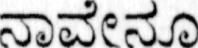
ನಾವೇನೂ
